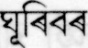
ঘূৰিবৰ
